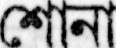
শোনা
